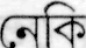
নেকি
